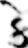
કે
